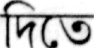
দিতে
